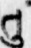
તું
